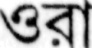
ওরা
